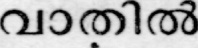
വാതില്‍
